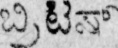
ಬ್ರಿಟಿಷ್
